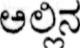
ಅಲ್ಲಿನ
